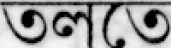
তলতে
